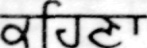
ਕਹਿਣਾ
